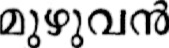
മുഴുവന്‍
